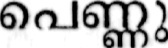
പെണ്ണു
